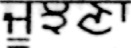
ਜੂਝਣਾ
